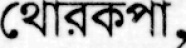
থোরকপা,
